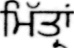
ਮਿੱਤ੍ਰਾਂ
